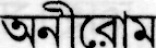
অনীরোম
